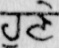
ਹੁਣੇ
